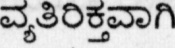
ವ್ಯತಿರಿಕ್ತವಾಗಿ
